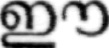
ഈ
